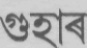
গুহাৰ
